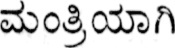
ಮಂತ್ರಿಯಾಗಿ
